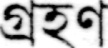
গ্রহণ
